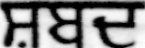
ਸ਼ਬਦ
